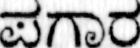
ಪಗಾರ
